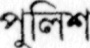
পুলিশ
